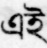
এই
